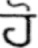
ਹੋ
